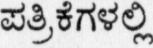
ಪತ್ರಿಕೆಗಳಲ್ಲಿ
